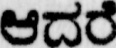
ಆದರೆ
